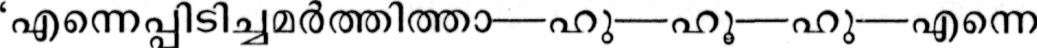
‘എന്നെപ്പിടിച്ചമര്‍ത്തിത്താ-ഹു-ഹൂ-ഹു-എന്നെ
